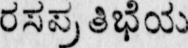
ರಸಪ್ರತಿಭೆಯ
